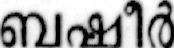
ബഷീര്‍
